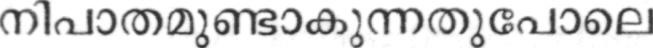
നിപാതമുണ്ടാകുന്നതുപോലെ
